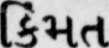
કિંમત
